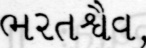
ભરતશ્વૈવ,
